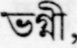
ভগ্নী,
